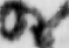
જ
